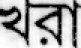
খরা
